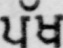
ਪੱਖ
